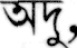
অদু,
